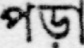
পড়া
